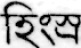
হিংস্র
